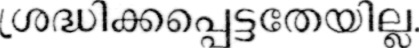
ശ്രദ്ധിക്കപ്പെട്ടതേയില്ല.
